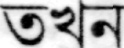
তখন
